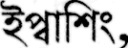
ইপ্বাশিং,
